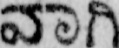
ವಾಗಿ
